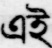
এই
